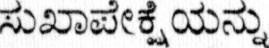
ಸುಖಾಪೇಕ್ಷೆಯನ್ನು
